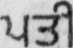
ਪਤੀ
